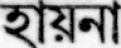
হায়না
